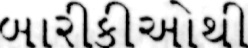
બારીકીઓથી
